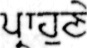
ਪ੍ਰਾਹੁਣੇ
